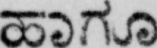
ಹಾಗೂ
